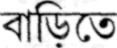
বাড়িতে
